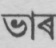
ভাৰ
